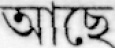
আছে
